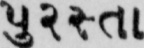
પુરસ્તા
